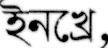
ইনখ্রে,
